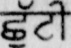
ਛੁੱਟੀ
